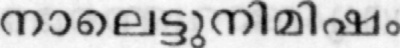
നാലെട്ടുനിമിഷം
